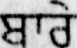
ਬਾਰੇ
